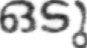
ഒടു
